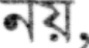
নয়,
